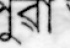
পুৱা
